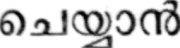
ചെയ്യാന്‍
